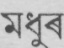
মধুৰ
